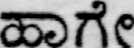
ಹಾಗೆ
